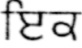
ਇਕ
